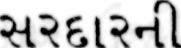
સરદારની
